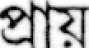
প্রায়
